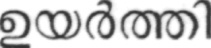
ഉയര്‍ത്തി
